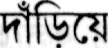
দাঁড়িয়ে
